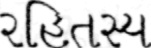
રહિતસ્ય
